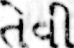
તેવી
